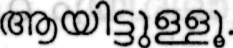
ആയിട്ടുള്ളൂ.
